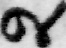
જ
